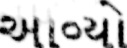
આવ્યો
